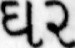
ઘર
